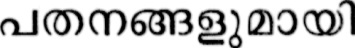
പതനങ്ങളുമായി
